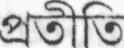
প্রতীতি
